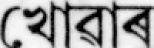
খোৱাৰ
